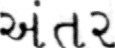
અતંર
